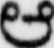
ಆ
